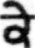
ਕੇ
